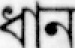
ধান
